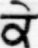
ਕੇ
